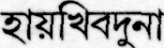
হায়খিবদুনা
